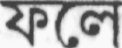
ফলে
